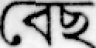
বেছ
